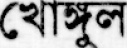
খোঙ্গুল
